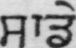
ਸਾਡੇ
